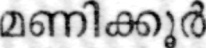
മണിക്കൂര്‍
